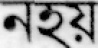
নহয়
